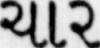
ચાર
